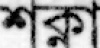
শক্না
